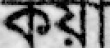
কয়া
